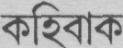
কহিবাক
